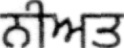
ਨੀਅਤ
